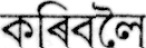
কৰিবলৈ
